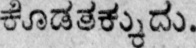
ಕೊಡತಕ್ಕುದು.
